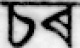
চৰ
